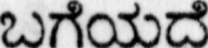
ಬಗೆಯದೆ
